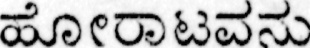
ಹೋರಾಟವನು
